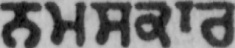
ਨਮਸਕਾਰ
